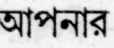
আপনার
